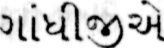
ગાંધીજીએ
